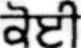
ਕੋਈ
